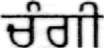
ਚੰਗੀ
